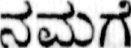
ನಮಗೆ
